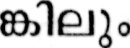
ങ്കിലും
